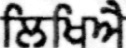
ਲਿਖਿਐ
